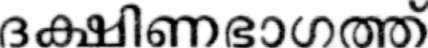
ദക്ഷിണഭാഗത്ത്
